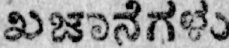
ಖಜಾನೆಗಳು
